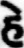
હે
